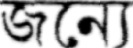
জন্যে
